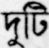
দুটি
